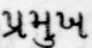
પ્રમુખ
